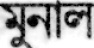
মুনাল
